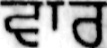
ਵਾਰ
